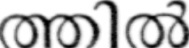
ത്തില്‍
